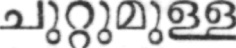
ചുറ്റുമുള്ള
